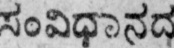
ಸಂವಿಧಾನದ
